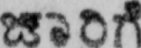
ಜಾರಿಗೆ
